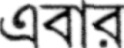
এবার
